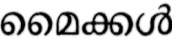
മൈക്കള്‍
